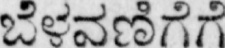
ಬೆಳವಣಿಗೆಗೆ
